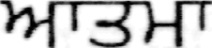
ਆਤਮਾ
